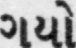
ગયો
